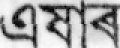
এষাৰ
